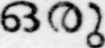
ഒരു
